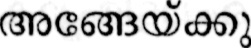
അങ്ങേയ്ക്കു
